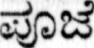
ಪೂಜೆ
